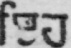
ਇਹ
